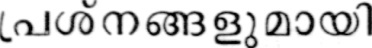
പ്രശ്നങ്ങളുമായി
